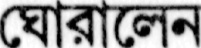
ঘোরালেন
